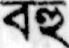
বহু
